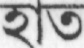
হাত
